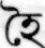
হৈ
